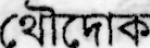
থৌদোক
